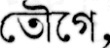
তৌগে,
